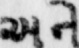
અને
